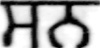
ਸਨ
